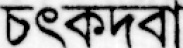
চৎকদবা
